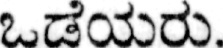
ಒಡೆಯರು.
